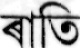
ৰাতি
